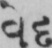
વેદ
